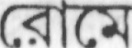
রোমে
